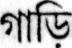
গাড়ি
